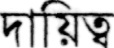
দায়িত্ব
